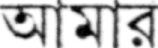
আমার
